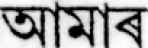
আমাৰ
